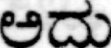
ಅದು
